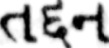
તદ્દન
